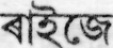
ৰাইজে
